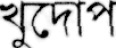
খুদোপ
